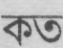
কত
